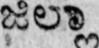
ಜಿಲ್ಲಾ
